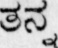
ತನ್ನ
